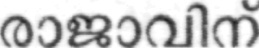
രാജാവിന്
